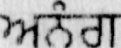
ਅਨੰਗ
